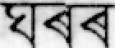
ঘৰৰ
